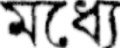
মধ্যে
